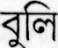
বুলি
